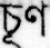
চূণ
